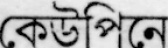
কেউপিনে
